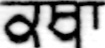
ਕਥਾ
